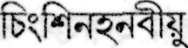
চিংশিনহনবীয়ু
